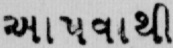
આપવાથી
